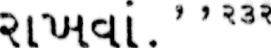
રાખવાં."૨૩૨
